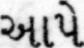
આપે
